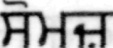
ਸੋਮਜ਼
